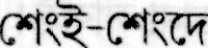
শেংই-শেংদে
